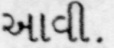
આવી.
